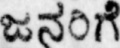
ಜನರಿಗೆ
